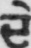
ਦੇ
